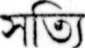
সত্যি
